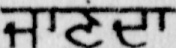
ਜਾਣਦਾ
